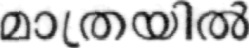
മാത്രയില്‍
